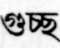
গুচ্ছ
